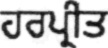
ਹਰਪ੍ਰੀਤ
